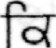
ਕਿ
